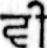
ਵੀ
